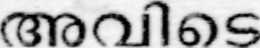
അവിടെ
